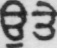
ਉਤੇ
